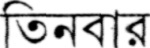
তিনবার
